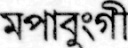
মপাবুংগী
